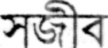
সজীব
